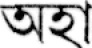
অহা
